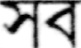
সব
